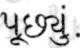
પૂછ્યું.
